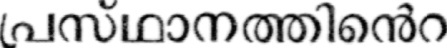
പ്രസ്ഥാനത്തിന്റെ
